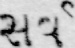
સર્વ
